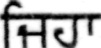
ਜਿਹਾ
